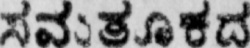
ಸಮತೂಕದ
